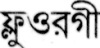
ফ্লুওরগী
